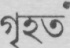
গৃহত
